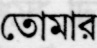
তোমার
